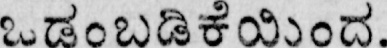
ಒಡಂಬಡಿಕೆಯಿಂದ.
